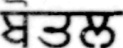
ਬੋਤਲ
